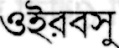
ওইরবসু
